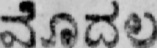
ಮೊದಲ
